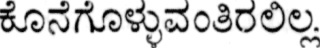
ಕೊನೆಗೊಳ್ಳುವಂತಿರಲಿಲ್ಲ.
